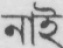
নাই
